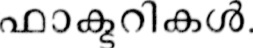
ഫാക്ടറികള്‍.
